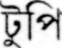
টুপি
